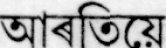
আৰতিয়ে
